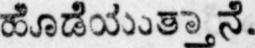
ಹೊಡೆಯುತ್ತಾನೆ.
